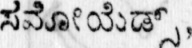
ಸಮೋಯೆಡ್ಸ್,
